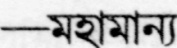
–মহামান্য
